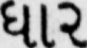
ધાર
